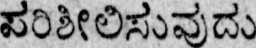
ಪರಿಶೀಲಿಸುವುದು
